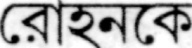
রোহনকে
